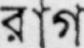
রাগ
